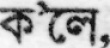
ক'লে,
